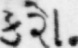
કરો.
